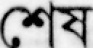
শেষ
